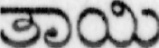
ತಾಯಿ
